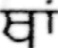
ਥਾਂ
